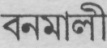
বনমালী
